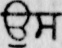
ਉਸ
